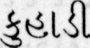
કુહાડી
